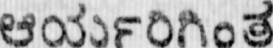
ಆರ್ಯರಿಗಿಂತ
